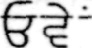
ਓਵੇਂ
